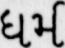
ધર્મ
